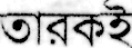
তারকই
